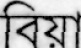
বিয়া
